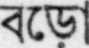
বড়ো
